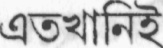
এতখানিই
